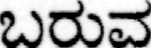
ಬರುವ
